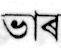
ভাৰ
